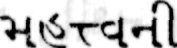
મહત્ત્વની
